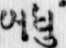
બધું
